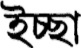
ইচ্ছা
